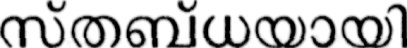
സ്തബ്ധയായി
